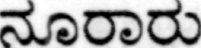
ನೂರಾರು
